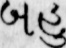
બહુ
